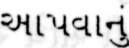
આપવાનું
